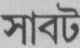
সাবট
